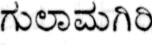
ಗುಲಾಮಗಿರಿ
